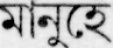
মানুহে
